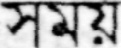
সময়
